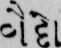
વૈદો
